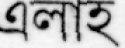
এলাহ
